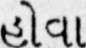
હોવા
